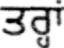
ਤਰ੍ਹਾਂ
